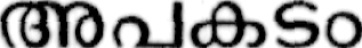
അപകടം
